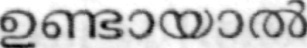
ഉണ്ടായാല്‍
